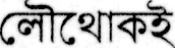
লৌথোকই
